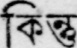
কিন্তু
